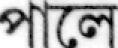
পালে
